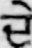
ਦੇ
